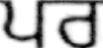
ਪਰ
